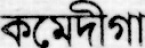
কমেদীগা
